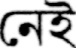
নেই
